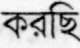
করছি
